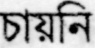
চায়নি
